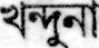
খন্দুনা
